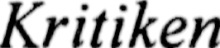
Kritiken
